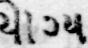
યોગ્ય
